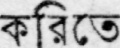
করিতে
